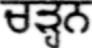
ਚੜ੍ਹਨ
